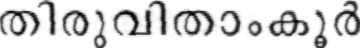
തിരുവിതാംകൂര്‍
